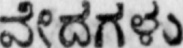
ವೇದಗಳು
